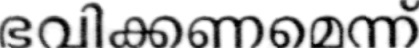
ഭവിക്കണമെന്ന്
